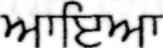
ਆਇਆ
